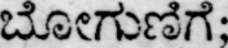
ಬೋಗುಣಿಗೆ;
